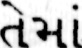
તેમાં
